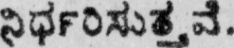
ನಿರ್ಧರಿಸುತ್ತವೆ.
